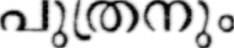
പുത്രനും
